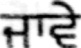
ਜਾਵੇ
